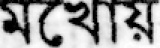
মখোয়
